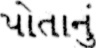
પોતાનું
